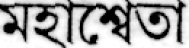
মহাশ্বেতা
